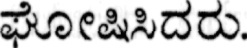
ಘೋಷಿಸಿದರು.
